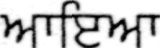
ਆਇਆ
